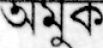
অমুক
